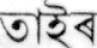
তাইৰ
